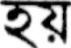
হয়
